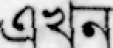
এখন
